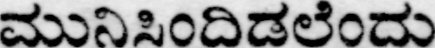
ಮುನಿಸಿಂದಿಡಲೆಂದು
